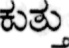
ಕುತ್ತು
